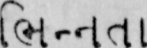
ભિન્નતા
